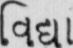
વિધા
